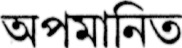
অপমানিত
